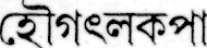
হৌগৎলকপা
